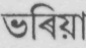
ভৰিয়া
